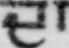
ਦਾ
